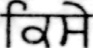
ਕਿਸੇ
